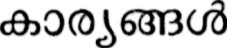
കാര്യങ്ങള്‍
